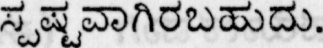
ಸ್ಪಷ್ಟವಾಗಿರಬಹುದು.
